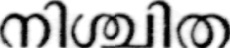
നിശ്ചിത
